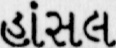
હાંસલ
